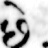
છે.
